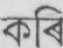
কৰি
